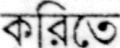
করিতে
